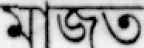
মাজত
